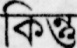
কিন্তু
